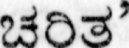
ಚರಿತ’
